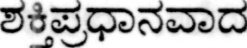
ಶಕ್ತಿಪ್ರಧಾನವಾದ
